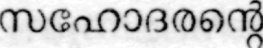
സഹോദരന്റെ
